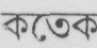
কতেক
